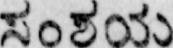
ಸಂಶಯ
